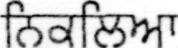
ਨਿਕਲਿਆ
